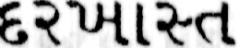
દરખાસ્ત
